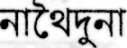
নাথৈদুনা
